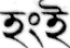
হংই
